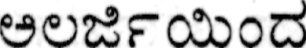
ಅಲರ್ಜಿಯಿಂದ
